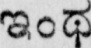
ಇಂಥ
